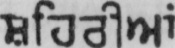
ਸ਼ਹਿਰੀਆਂ
